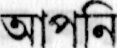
আপনি
